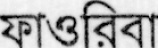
ফাওরিবা
